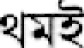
থমই
